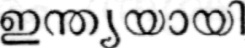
ഇന്ത്യയായി
